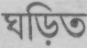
ঘড়িত
